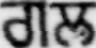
ਗਲ
